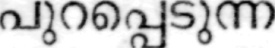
പുറപ്പെടുന്ന
